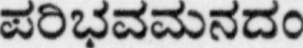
ಪರಿಭವಮನದಂ
